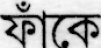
ফাঁকে
